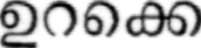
ഉറക്കെ
